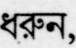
ধরুন,
